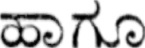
ಹಾಗೂ
